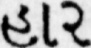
હાર
